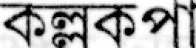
কল্লকপা
